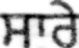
ਸਾਰੇ
